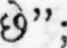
છે";
